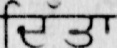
ਦਿੱਤਾ
